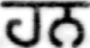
ਹਨ
